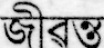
জীৱন্ত
